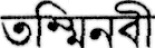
তম্মিনবী
